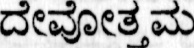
ದೇವೋತ್ತಮ
